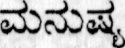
ಮನುಷ್ಯ
